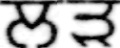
ਲੜ
